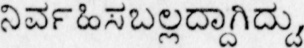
ನಿರ್ವಹಿಸಬಲ್ಲದ್ದಾಗಿದ್ದು,
